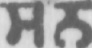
ਸਨ
